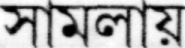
সামলায়
